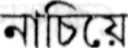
নাচিয়ে
